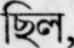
ছিল,
